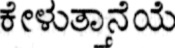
ಕೇಳುತ್ತಾನೆಯೆ
